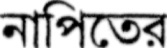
নাপিতের
